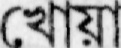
খোয়া
